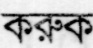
করুক
